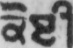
ਕੋਈ
